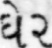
ઘેર
